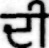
ਦੀ
